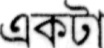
একটা
